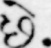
છે.
